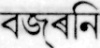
বজ্‌ৰনি
